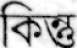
কিন্তু
